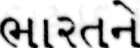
ભારતને
